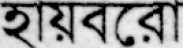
হায়বরো
